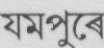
যমপুৰে
